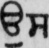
ਉਸ
